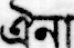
ঐনা
